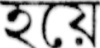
হয়ে
